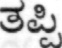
ತಪ್ಪಿ
